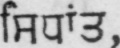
ਸਿਧਾਂਤ,
